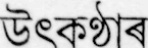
উৎকণ্ঠাৰ
